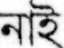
নাই
